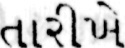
તારીખે
